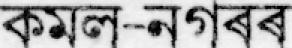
কমল-নগৰৰ
